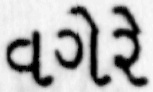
વગેરે
